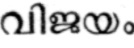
വിജയം
